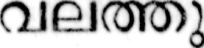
വലത്തു
